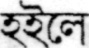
হইলে
